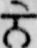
ਨੇ
